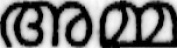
അമ്മ
